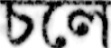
চলে
